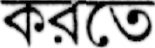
করতে
